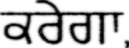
ਕਰੇਗਾ,
